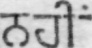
ਨਹੀਂ
